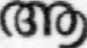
ആ
